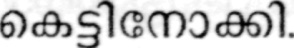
കെട്ടിനോക്കി.
